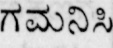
ಗಮನಿಸಿ
